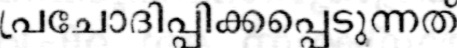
പ്രചോദിപ്പിക്കപ്പെടുന്നത്
